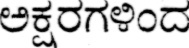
ಅಕ್ಷರಗಳಿಂದ
